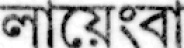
লায়েংবা
